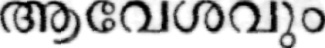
ആവേശവും
